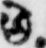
છે.
